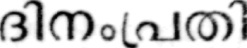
ദിനംപ്രതി
